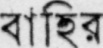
বাহির
